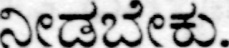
ನೀಡಬೇಕು.
